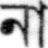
না
